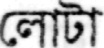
লোটা
